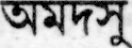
অমদসু
